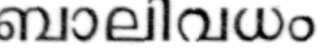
ബാലിവധം
